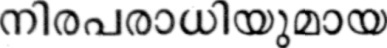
നിരപരാധിയുമായ
